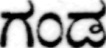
ಗಂಡ
